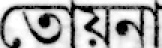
তোয়না
